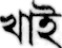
খাই
